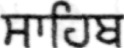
ਸਾਹਿਬ
